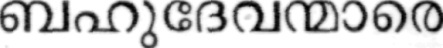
ബഹുദേവന്മാരെ
